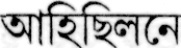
আহিছিলনে
